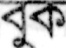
বুক
